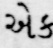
એક
